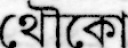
থৌকো
